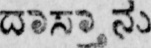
ದಾಸ್ತಾನು
